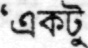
‘একটু
